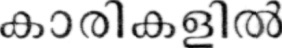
കാരികളില്‍
